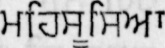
ਮਹਿਸੂਸਿਆ
